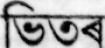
ভিতৰ
